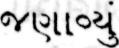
જણાવ્યું
